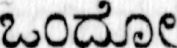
ಒಂದೋ
